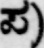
ಪ)
